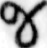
જ
